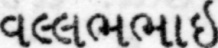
વલ્લભભાઈ
